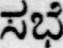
ಸಭೆ
